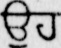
ਉਹ
